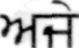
ਅਜੇ
